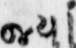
જ્યાં
